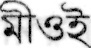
মীওই
